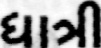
ધાત્રી
